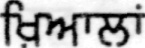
ਖ਼ਿਆਲਾਂ
